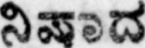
ನಿಷಾದ
